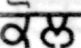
ਕੋਲ
